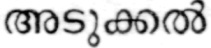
അടുക്കല്‍
